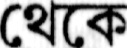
থেকে
